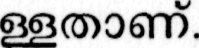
ള്ളതാണ്.
